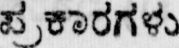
ಪ್ರಕಾರಗಳು
